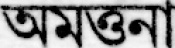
অমত্তনা
